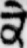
ਕੇ
